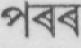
পৰৰ
